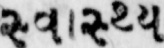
સ્વાસ્થ્ય
